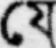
যে
